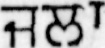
ਜਲਾ
